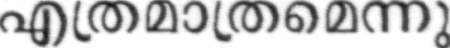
എത്രമാത്രമെന്നു
